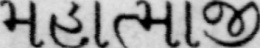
મહાત્માજી
